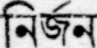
নির্জন
